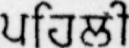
ਪਹਿਲੀ
